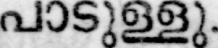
പാടുള്ളു.
